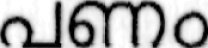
പണം
